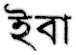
ইবা
